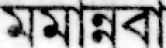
মমান্নবা
